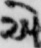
એ
